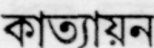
কাত্যায়ন
